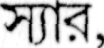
স্যার,
